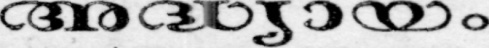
അദ്ധ്യായം
